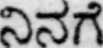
ನಿನಗೆ
